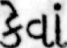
કેવાં
